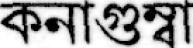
কনাগুম্বা
